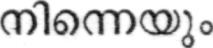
നിന്നെയും
